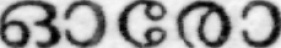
ഓരോ
